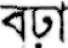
বঢ়া
